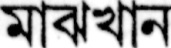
মাঝখান
